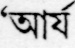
‘আর্য
